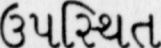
ઉપસ્થિત
